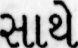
સાથે
